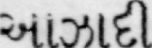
આઝાદી
